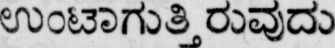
ಉಂಟಾಗುತ್ತಿರುವುದು
